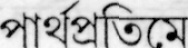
পার্থপ্রতিমে
